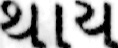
થાય
